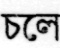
চলে
